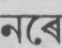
নৰে
